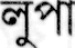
লুপা
